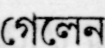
গেলেন
